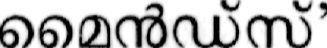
മൈന്‍ഡ്സ്’
